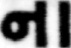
ના
